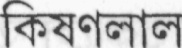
কিষণলাল
